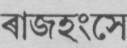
ৰাজহংসে
